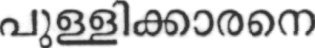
പുള്ളിക്കാരനെ
